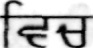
ਵਿਚ
